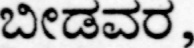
ಬೀಡವರ,
